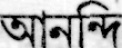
আনন্দি
